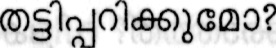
തട്ടിപ്പറിക്കുമോ?
